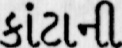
કાંટાની
